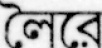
লৈরে
